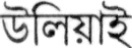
উলিয়াই
